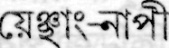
য়েঞ্ছাং-নাপী
